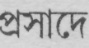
প্ৰসাদে
